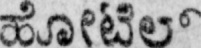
ಹೋಟೆಲ್
